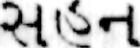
સહન
